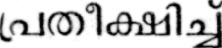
പ്രതീക്ഷിച്ച്
